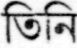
তিনি
